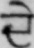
ਦੇ
